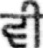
ਵੀ
